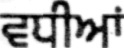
ਵਧੀਆਂ
